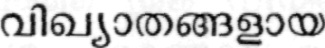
വിഖ്യാതങ്ങളായ
